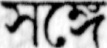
সঙ্গে
